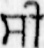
ਸੀ
